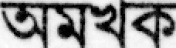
অমখক
